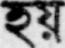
হয়
